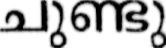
ചുണ്ടു
